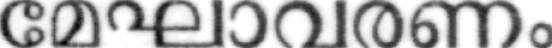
മേഘാവരണം
